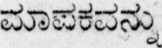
ಮಾಪಕವನ್ನು
